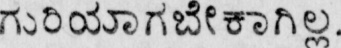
ಗುರಿಯಾಗಬೇಕಾಗಿಲ್ಲ.
